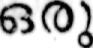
ഒരു
